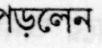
পড়লেন
